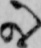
જે
